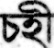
চহী
